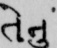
તેનું
